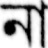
না
